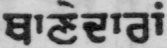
ਥਾਣੇਦਾਰਾਂ
